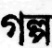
গল্প
